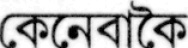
কেনেবাকৈ
